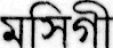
মসিগী
